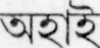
অহাই
